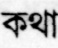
কথা
